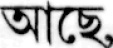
আছে,
